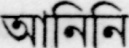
আনিনি
